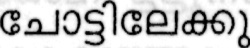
ചോട്ടിലേക്കു
